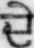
ਦੇ
